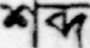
শব্দ
